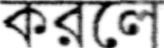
করলে
